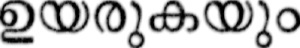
ഉയരുകയും
